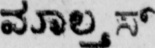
ಮಾಲ್ತಸ್
